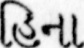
હિના
